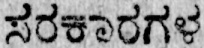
ಸರಕಾರಗಳ
